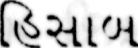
હિસાબ
